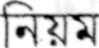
নিয়ম
